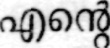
എന്റെ
